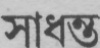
সাধন্ত
